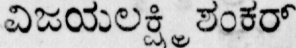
ವಿಜಯಲಕ್ಷ್ಮಿಶಂಕರ್
